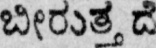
ಬೀರುತ್ತದೆ
